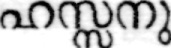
ഹസ്സനു
